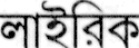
লাইরিক
